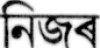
নিজৰ
